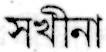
সখীনা
